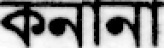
কনানা
